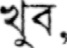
খুব,
